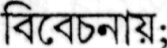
বিবেচনায়;
